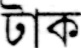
টাক
